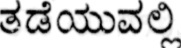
ತಡೆಯುವಲ್ಲಿ
